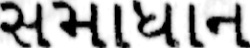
સમાધાન
